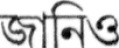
জানিও
